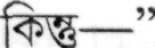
কিন্তু-"
